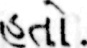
હતો.
